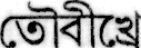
তৌবীখ্রে
